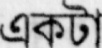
একটা
